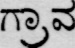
ಗ್ರಾವ
